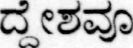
ದ್ದೇಶವೂ
